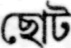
ছোট
